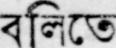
বলিতে
